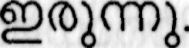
ഇരുന്നു.
